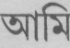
আমি
